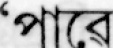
'পাৱে
